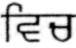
ਵਿਚ
